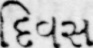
દિવસ
